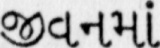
જીવનમાં
